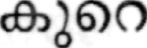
കുറെ
